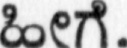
ಹೀಗೆ.
